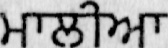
ਮਾਲੀਆ
